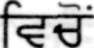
ਵਿਚੋਂ
